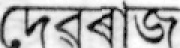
দেৱৰাজ
